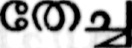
തേച്ച
